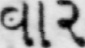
વાર
